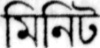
মিনিট
